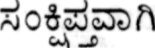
ಸಂಕ್ಷಿಪ್ತವಾಗಿ
